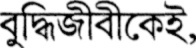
বুদ্ধিজীবীকেই,
